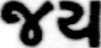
જય
